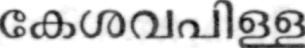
കേശവപിള്ള
